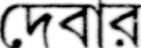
দেবার
